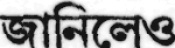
জানিলেও
